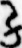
કે
